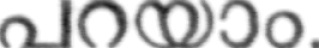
പറയാം.
